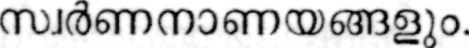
സ്വര്‍ണനാണയങ്ങളും.
